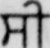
ਸੀ
